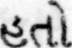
હતો
